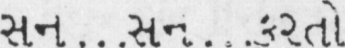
સન...સન...કરતો
